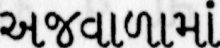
અજવાળામાં
